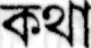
কথা
